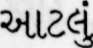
આટલું
